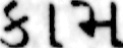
કામ
